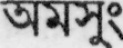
অমসুং
